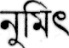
নুমিৎ
